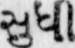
સુધી
